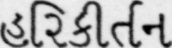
હરિકીર્તન
